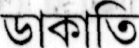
ডাকাতি
